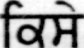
ਕਿਸੇ
